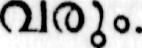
വരും.
